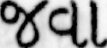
જવા
